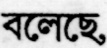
বলেছে,
